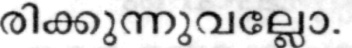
രിക്കുന്നുവല്ലോ.
